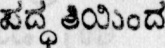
ಪದ್ಧತಿಯಿಂದ
